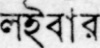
লইবার
